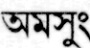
অমসুং
